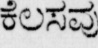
ಕೆಲಸವು
